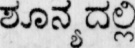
ಶೂನ್ಯದಲ್ಲಿ
